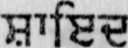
ਸ਼ਾਇਦ
